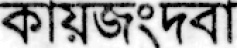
কায়জংদবা
